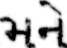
મને
